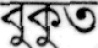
বুকুত
